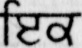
ਇਕ
